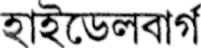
হাইডেলবার্গ
